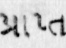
પ્રાપ્ત
